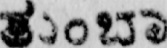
ತುಂಬಾ
